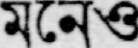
মনেও
